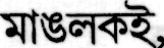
মাঙলকই,
